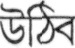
উঠিব
